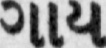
ગાય
